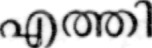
എത്തി
